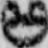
ಅ
